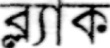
ব্ল্যাক
